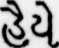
હૈયે
